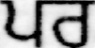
ਪਰ
